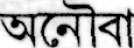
অনৌবা
